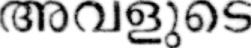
അവളുടെ
